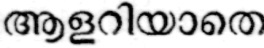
ആളറിയാതെ
